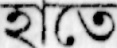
হাতে
